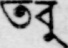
তবু
